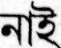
নাই
